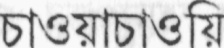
চাওয়াচাওয়ি
